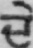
ਦੇ
